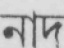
নাদ
